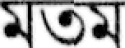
মতম
